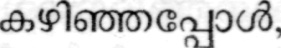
കഴിഞ്ഞപ്പോള്‍,
